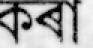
কৰা
